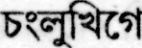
চংলুখিগে
